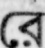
রে
